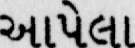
આપેલા
